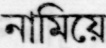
নামিয়ে
